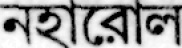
নহারোল
